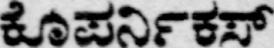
ಕೊಪರ್ನಿಕಸ್
